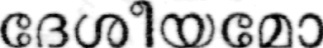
ദേശീയമോ
